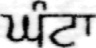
ਘੰਟਾ
